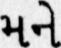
મને
